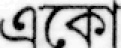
একো
